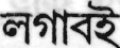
লগাবই
